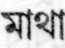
মাথা
